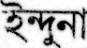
ইন্দুনা
